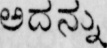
ಅದನ್ನು
